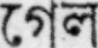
গেল
